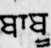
ਬਾਬੂ
